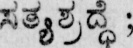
ಸತ್ಯಶ್ರದ್ಧೆ;
